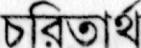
চরিতার্থ
